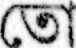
তো
